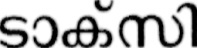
ടാക്സി
